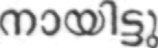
നായിട്ടു
